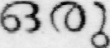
ഒരു
